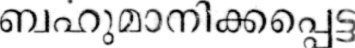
ബഹുമാനിക്കപ്പെട്ട
